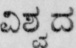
ವಿಶ್ವದ
